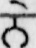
ਨੇ
